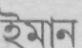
ইমান
